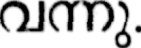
വന്നു.
